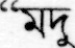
“মাদু
